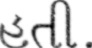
હતી.
